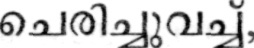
ചെരിച്ചുവച്ച്,
